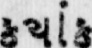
ક્યાંક
